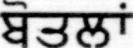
ਬੋਤਲਾਂ
